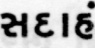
સદાહં
